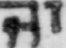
ਜਾ
